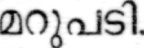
മറുപടി.
